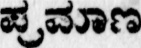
ಪ್ರಮಾಣ
